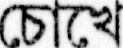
চোখে
